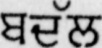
ਬਦੱਲ
